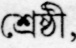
শ্রেষ্ঠী,
